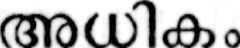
അധികം
